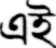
এই
